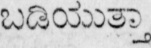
ಬಡಿಯುತ್ತಾ
